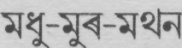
মধু-মুৰ-মথন
